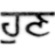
ਹੁਣ
